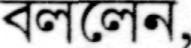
বললেন,
